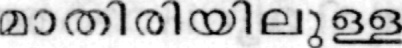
മാതിരിയിലുള്ള
